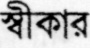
স্বীকার
